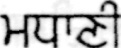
ਮਧਾਣੀ
